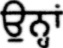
ਉਨ੍ਹਾਂ
